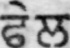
ਫੇਲ
